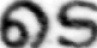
ടെ
